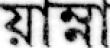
য়াম্না
